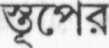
স্তূপের
